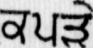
ਕਪੜੇ
